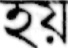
হয়
